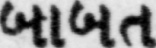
બાબત
